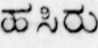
ಹಸಿರು
